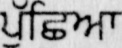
ਪੁੱਛਿਆ
